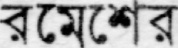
রমেশের
